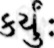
કર્યું:
